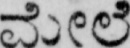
ಮೇಲೆ
